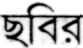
ছবির
